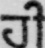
ਹੀ
